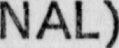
NAL)
